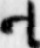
ન
